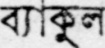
ব্যাকুল
